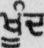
ਖੂੰਦ
